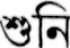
শুনি
